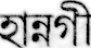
হান্নগী
